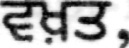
ਵਖ਼ਤ,
